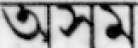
অসম
